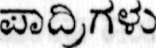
ಪಾದ್ರಿಗಳು
